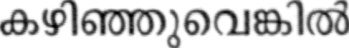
കഴിഞ്ഞുവെങ്കില്‍
